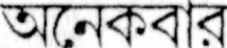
অনেকবার
